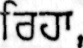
ਰਿਹਾ,
